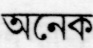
অনেক
